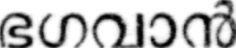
ഭഗവാന്‍
